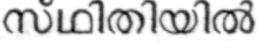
സ്ഥിതിയില്‍
